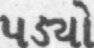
પડ્યો
